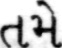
તમે
